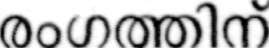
രംഗത്തിന്
